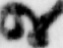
જ
